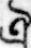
ঐ
